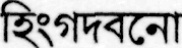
হিংগদবনো
